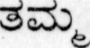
ತಮ್ಮ
